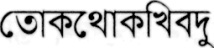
তোকথোকখিবদু
